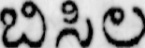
ಬಿಸಿಲ
